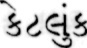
કેટલુંક
